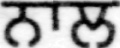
ਨਾਲ
